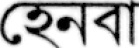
হেনবা
